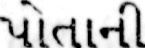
પોતાની
